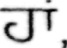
ਹਾਂ,
